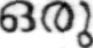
ഒരു
